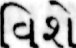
વિશે
